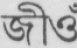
জীওঁ
